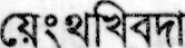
য়েংথখিবদা
